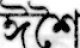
ঈশৈ
